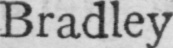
Bradley
